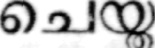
ചെയ്ത
